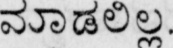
ಮಾಡಲಿಲ್ಲ.
